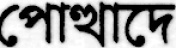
পোত্থাদে
